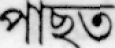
পাছত
